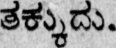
ತಕ್ಕುದು.
